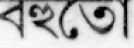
বহুতো
